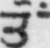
ਤੋਂ
